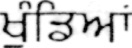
ਖੁੰਡਿਆਂ
